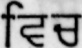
ਵਿਚ
